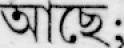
আছে;
